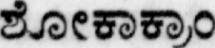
ಶೋಕಾಕ್ರಾಂ
